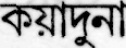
কয়াদুনা
